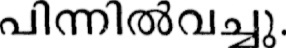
പിന്നില്‍വച്ചു.
